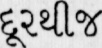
દૂરથીજ
